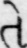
તે
